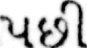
પછી
